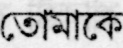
তোমাকে
